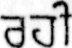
ਰਹੀ
